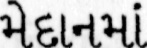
મેદાનમાં
